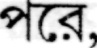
পরে,
